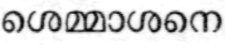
ശെമ്മാശനെ
